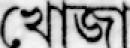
খোজা
